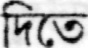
দিতে
